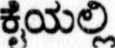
ಕೈಯಲ್ಲಿ
